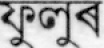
ফুলুৰ
